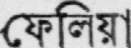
ফেলিয়া
